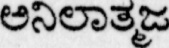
ಅನಿಲಾತ್ಮಜ
